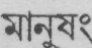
মানুষং
